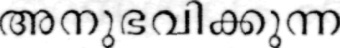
അനുഭവിക്കുന്ന
